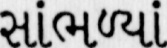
સાંભળ્યાં
